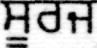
ਸੂਰਜ
